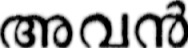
അവന്‍
